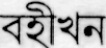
বহীখন
